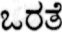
ಒರತೆ
